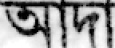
আদা
